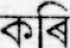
কৰি
